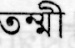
তম্মী
